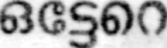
ഒട്ടേറെ
